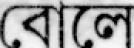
বোলে
